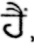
ਹੈਂ,
